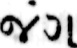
જંગ
